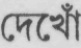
দেখোঁ
